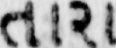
તારા
